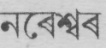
নৰেশ্বৰ
